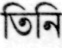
তিনি
